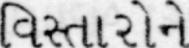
વિસ્તારોને
